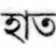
হাত
